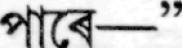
পাৰে-"
